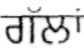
ਗੱਲਾਂ
